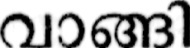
വാങ്ങി
